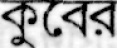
কুবের
